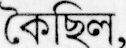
কৈছিল,
